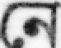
নে
